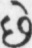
છે
